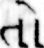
તો
